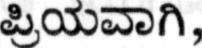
ಪ್ರಿಯವಾಗಿ,
